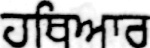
ਹਥਿਆਰ
